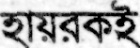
হায়রকই
